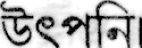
উৎপনি।
